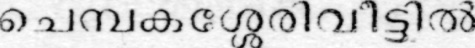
ചെമ്പകശ്ശേരിവീട്ടില്‍
